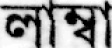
লাম্বা
